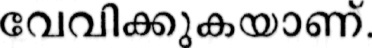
വേവിക്കുകയാണ്.
